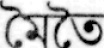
মৈতৈ
